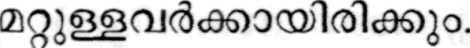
മറ്റുള്ളവര്‍ക്കായിരിക്കും.
